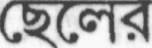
ছেলের
